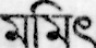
মমিৎ
